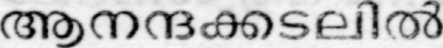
ആനന്ദക്കടലില്‍
